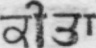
ਕੀਤਾ
